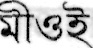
মীওই
